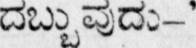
ದಬ್ಬುವುದು-’
